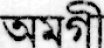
অমগী
